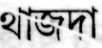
থাজদা
